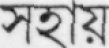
সহায়
